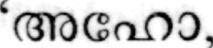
'അഹോ,
